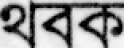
থবক
